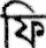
ফি
